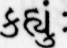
કહ્યું:
